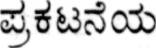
ಪ್ರಕಟನೆಯ
